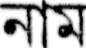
নাম
